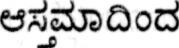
ಆಸ್ತಮಾದಿಂದ
